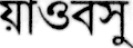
য়াওবসু
